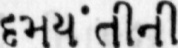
દમયંતીની
